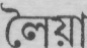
লৈয়া
